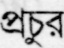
প্রচুর
